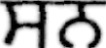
ਸਨ
